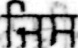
ਜਿਸ
